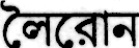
লৈরোন
